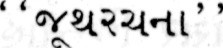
"જૂથરચના"
